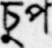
চুপ
